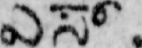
ಎಸ್.
